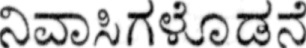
ನಿವಾಸಿಗಳೊಡನೆ
